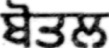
ਬੋਤਲ
